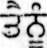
ਤੈਨੂੰ
